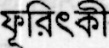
ফূরিৎকী
